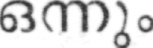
ഒന്നും
